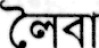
লৈবা
